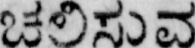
ಚಲಿಸುವ
